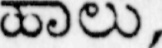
ಹಾಲು,
